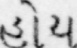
હોય
